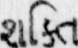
શક્તિ
